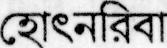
হোৎনরিবা
